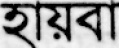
হায়বা
